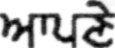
ਆਪਣੇ
